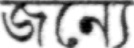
জন্যে
